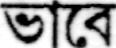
ভাবে
